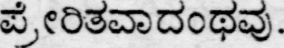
ಪ್ರೇರಿತವಾದಂಥವು.
